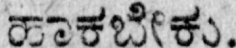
ಹಾಕಬೇಕು.
